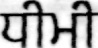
ਧੀਮੀ
